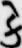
કે
